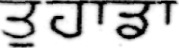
ਤੁਹਾਡਾ
